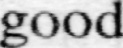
good
